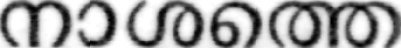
നാശത്തെ
